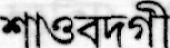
শাওবদগী
